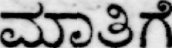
ಮಾತಿಗೆ
